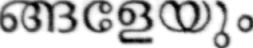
ങ്ങളേയും
